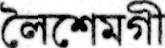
লৈশেমগী
